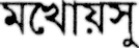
মখোয়সু
